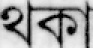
থকা
